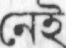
নেই
